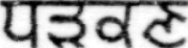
ਧੜਕਣ
